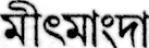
মীৎমাংদা
